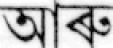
আৰু
